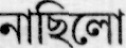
নাছিলো
